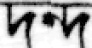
দন্দ
